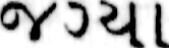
જગ્યા
